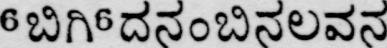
6ಬಿಗಿ6ದನಂಬಿನಲವನ
